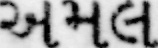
અમલ
